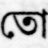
তো
